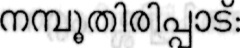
നമ്പൂതിരിപ്പാട്:
